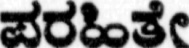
ಪರಹಿತೇ
